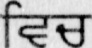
ਵਿਚ
